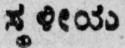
ಸ್ಥಳೀಯ
